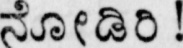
ನೋಡಿರಿ!
